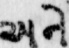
અને
